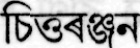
চিত্তৰঞ্জন
